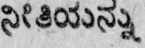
ನೀತಿಯನ್ನು
